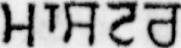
ਮਾਸਟਰ
